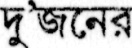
দু'জনের
